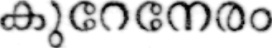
കുറേനേരം
